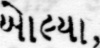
બોલ્યા,
